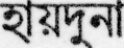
হায়দুনা
